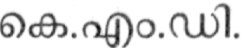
കെ.എം.ഡി.
